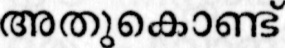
അതുകൊണ്ട്
